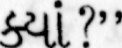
ક્યાં?"
